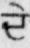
ਦੇ
